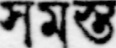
সমস্ত
